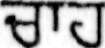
ਚਾਹ
